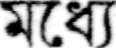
মধ্যে
